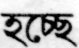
হচ্ছে
